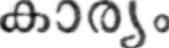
കാര്യം
